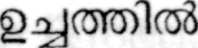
ഉച്ചത്തില്‍
